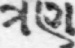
ત્રણ
